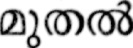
മുതല്‍
